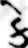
કે
